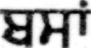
ਬਸਾਂ
